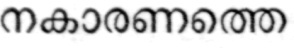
നകാരണത്തെ
